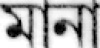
মানা
